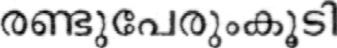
രണ്ടുപേരുംകൂടി
